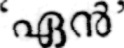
'ഏന്‍'
